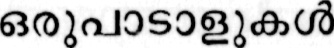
ഒരുപാടാളുകള്‍
